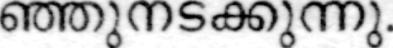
ഞ്ഞുനടക്കുന്നു.
